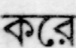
করে
